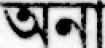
অনা
